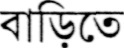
বাড়িতে
